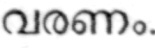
വരണം.
